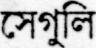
সেগুলি
